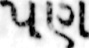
પણ
